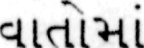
વાતોમાં
